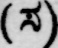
(ಸ)
